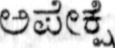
ಅಪೇಕ್ಷೆ
